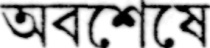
অবশেষে
